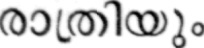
രാത്രിയും
